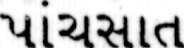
પાંચસાત
